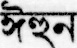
ঈহুন
